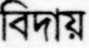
বিদায়
